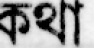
কথা
